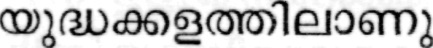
യുദ്ധക്കളത്തിലാണു
